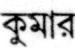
কুমার
